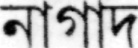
নাগাদ
